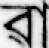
ৱা
